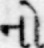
નો
